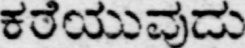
ಕರೆಯುವುದು
